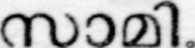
സാമി.
